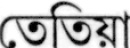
তেতিয়া
